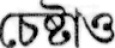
চেষ্টাও
